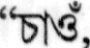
"চাওঁ,
